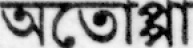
অতোপ্পা
